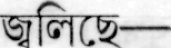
জ্বলিছে-
